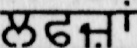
ਲਫਜ਼ਾਂ
